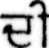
ਦੀ
